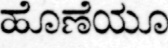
ಹೊಣೆಯೂ
